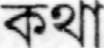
কথা
